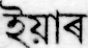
ইয়াৰ
